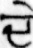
ਦੇ
